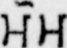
ਮੋਮ
